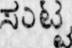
ಸುಟ್ಟ
